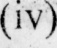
(iv)
